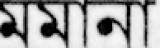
মমানা
